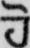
ਹੋ
